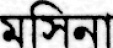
মসিনা
